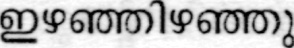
ഇഴഞ്ഞിഴഞ്ഞു
